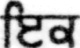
ਇਕ
